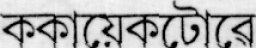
ককায়েকটোৱে
